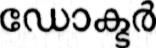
ഡോക്ടര്‍
